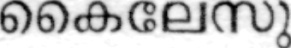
കൈലേസു
